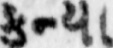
કન્યા
